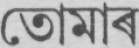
তোমাৰ
